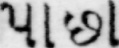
પાછા
